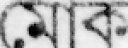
মোক
